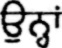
ਉਨ੍ਹਾਂ
